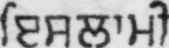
ਇਸਲਾਮੀ
